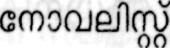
നോവലിസ്റ്റ്
